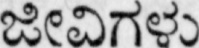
ಜೀವಿಗಳು
